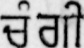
ਚੰਗੀ
